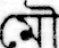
মৌ
